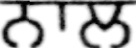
ਨਾਲ
